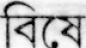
বিষে
